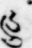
હું
